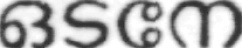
ഒടനേ
